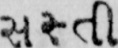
સસ્તી
